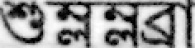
শুম্লম্লব্রা
